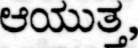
ಆಯುತ್ತ,
